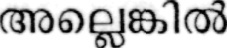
അല്ലെങ്കില്‍
